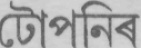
টোপনিৰ
